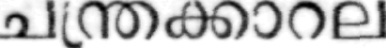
ചന്ത്രക്കാറല
